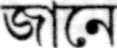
জানে
